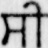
ਸੀ
